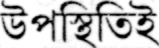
উপস্থিতিই
